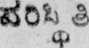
ಪರಿಸ್ಥಿತಿ
